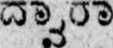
ದ್ವಾರಾ
